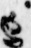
હું
